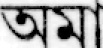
অমা
